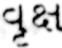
વૃક્ષ
